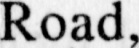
Road,
